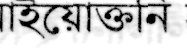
মাইয়োক্তনি
